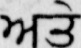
ਅਤੇ
